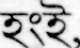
হংই,
